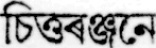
চিত্তৰঞ্জনে
